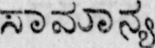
ಸಾಮಾನ್ಯ
